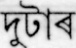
দুটাৰ
